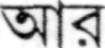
আর
